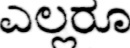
ಎಲ್ಲರೂ
